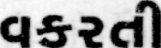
વકરતી
